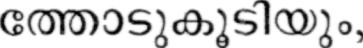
ത്തോടുകൂടിയും,
